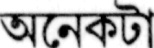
অনেকটা
